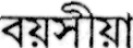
বয়সীয়া
